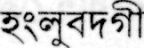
হংলুবদগী
